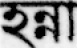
হন্না
